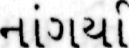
નાંગર્યા
